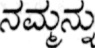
ನಮ್ಮನ್ನು
